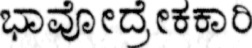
ಭಾವೋದ್ರೇಕಕಾರಿ
